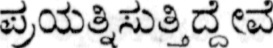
ಪ್ರಯತ್ನಿಸುತ್ತಿದ್ದೇವೆ
